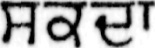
ਸਕਦਾ
